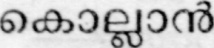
കൊല്ലാന്‍
